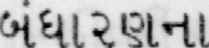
બંધારણના
